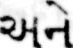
અને
